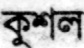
কুশল
